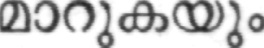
മാറുകയും
